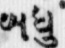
બધું
